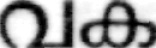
വക
